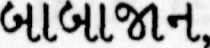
બાબાજાન,
